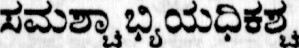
ಸಮಶ್ಚಾಭ್ಯಿಯಧಿಕಶ್ಚ
